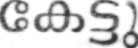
കേട്ടു
